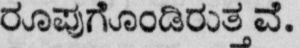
ರೂಪುಗೊಂಡಿರುತ್ತವೆ.
